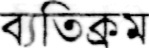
ব্যতিক্রম
